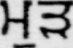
ਮੁੜ
